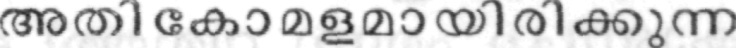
അതികോമളമായിരിക്കുന്ന
